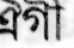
ঐগী
